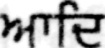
ਆਦਿ
